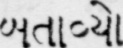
બતાવ્યો
